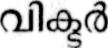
വിക്ടര്‍
